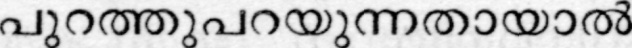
പുറത്തുപറയുന്നതായാല്‍
